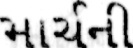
માર્ચની
